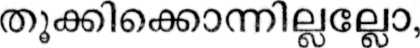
തൂക്കിക്കൊന്നില്ലല്ലോ,
